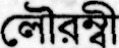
লৌরম্বী
